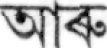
আৰু
